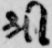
શ્રી
